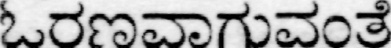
ಓರಣವಾಗುವಂತೆ
